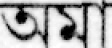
অমা
